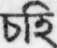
চহি
